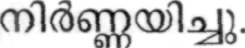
നിര്‍ണ്ണയിച്ചു.
